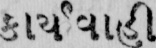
કાર્યવાહી
